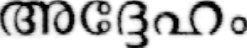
അദ്ദേഹം
